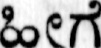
ಹೀಗೆ
